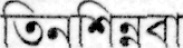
তিনশিন্নবা
